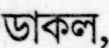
ডাকল,
